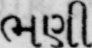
ભણી
